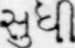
સુધી
